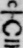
ਨੂੰ
